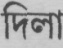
দিলা
